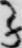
કે
